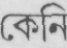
কেনি
